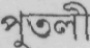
পুতলী
